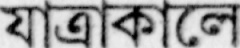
যাত্রাকালে
